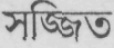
সজ্জিত
